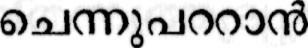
ചെന്നുപററാന്‍
